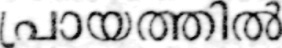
പ്രായത്തില്‍
